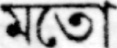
মতো
